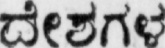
ದೇಶಗಳ
